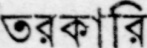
তরকারি
